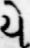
યે
